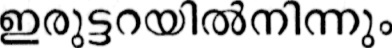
ഇരുട്ടറയില്‍നിന്നും
